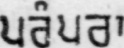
ਪਰੰਪਰਾ
